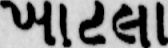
ખાટલા
